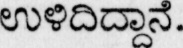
ಉಳಿದಿದ್ದಾನೆ.
